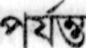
পর্যন্ত
